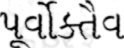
પૂર્વોકતૈવ
